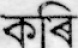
কৰি
